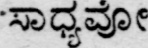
ಸಾಧ್ಯವೋ
